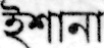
ইশানা
